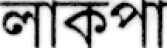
লাকপা
